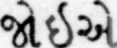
જોઈએ
